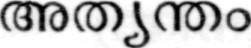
അത്യന്തം
